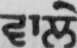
ਵਾਲੇ
